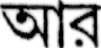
আর
